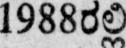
1988ರಲ್ಲಿ
